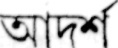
আদর্শ
